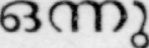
ഒന്നു
